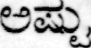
ಅಷ್ಟು
